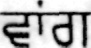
ਵਾਂਗ
